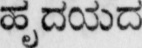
ಹೃದಯದ
